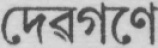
দেৱগণে
